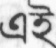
এই
